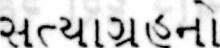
સત્યાગ્રહનો
